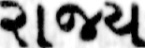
રાજ્ય
